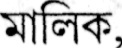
মালিক,
